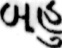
બહુ
